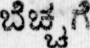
ಬೆಚ್ಚಗೆ
